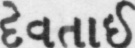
દેવતાઈ
